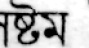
সষ্টম
